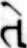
તે
